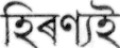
হিৰণ্যই
